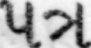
પત્ર
